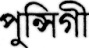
পুন্সিগী
